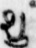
શું
